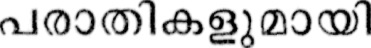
പരാതികളുമായി
